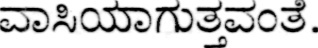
ವಾಸಿಯಾಗುತ್ತವಂತೆ.
